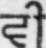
ਵੀ
